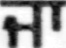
ਜਾ
